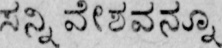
ಸನಿವೇಶವನ್ನೂ
